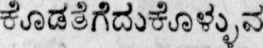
ಕೊಡತೆಗೆದುಕೊಳ್ಳುವ
